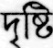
দৃষ্টি
